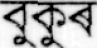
বুকুৰ
